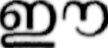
ഈ
